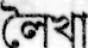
লৈখা
